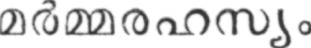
മര്‍മ്മരഹസ്യം
